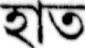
হাত
